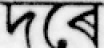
দৰে
